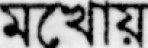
মখোয়
